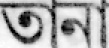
তানা
